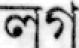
লগ
